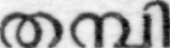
തമ്പി
